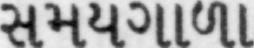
સમયગાળા
